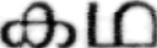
കഥ
